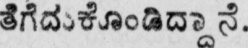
ತೆಗೆದುಕೊಂಡಿದ್ದಾನೆ.
